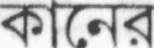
কানের
